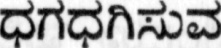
ಧಗಧಗಿಸುವ
